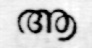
ആ
